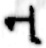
ન
